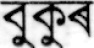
বুকুৰ
